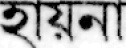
হায়না
